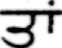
ਤਾਂ
